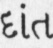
દાંત
